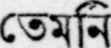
তেমনি
